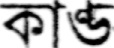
কাণ্ড
